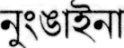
নুংঙাইনা
